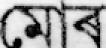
মোৰ
